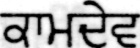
ਕਾਮਦੇਵ
